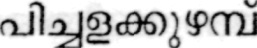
പിച്ചളക്കുഴമ്പ്
